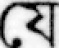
যে
